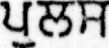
ਪੁਲਸ
